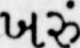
ખરું
